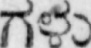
ಗಳು
